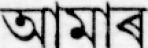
আমাৰ
